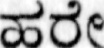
ಹರೇ
